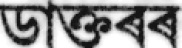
ডাক্তৰৰ
